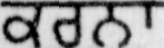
ਕਰਨਾ
